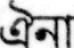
ঐনা
